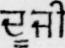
ਦੂਜੀ
